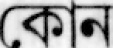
কোন
